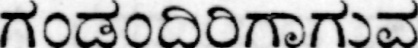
ಗಂಡಂದಿರಿಗಾಗುವ
